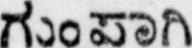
ಗುಂಪಾಗಿ
